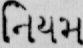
નિયમ
